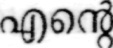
എന്റെ
